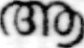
ആ
